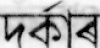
দর্কাৰ
